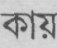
কায়
